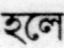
হলে
